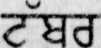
ਟੱਬਰ
